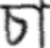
চা
